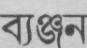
ব্যঞ্জন
